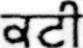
ਕਟੀ
